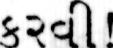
કરવી!
